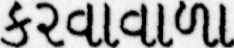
કરવાવાળા
